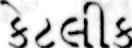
કેટલીક
